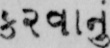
કરવાનું
